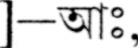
]–আঃ,
